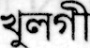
খুলগী
